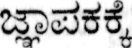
ಜ್ಞಾಪಕಕ್ಕೆ
